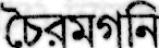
চৈরমগনি
